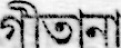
গীতানা
